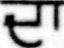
ਦਾ
